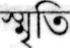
স্মৃতি
